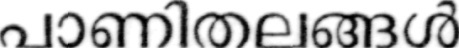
പാണിതലങ്ങള്‍
